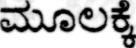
ಮೂಲಕ್ಕೆ
